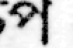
চপ
